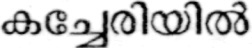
കച്ചേരിയില്‍
